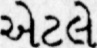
એટલે
